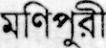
মণিপুরী
